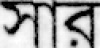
সার
